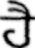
ਹੈ
